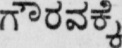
ಗೌರವಕ್ಕೆ
